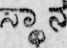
ಸ್ಥಾನ
